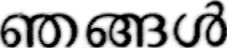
ഞങ്ങള്‍
